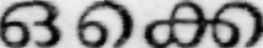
ഒക്കെ
